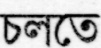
চলতে
